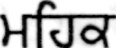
ਮਹਿਕ
